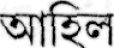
আহিল
